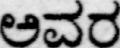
ಅವರ
